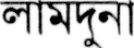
লামদুনা
